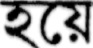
হয়ে
